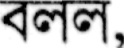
বলল,
